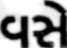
વસે
